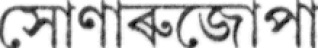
সোণাৰুজোপা
